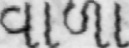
વાળા
